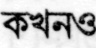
কখনও
